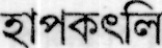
হাপকৎলি
